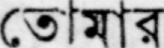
তোমার
